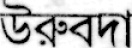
উরুবদা
